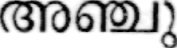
അഞ്ചു
